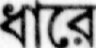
ধারে
